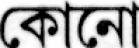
কোনো
